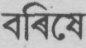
বৰিষে
